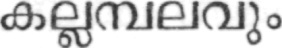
കല്ലമ്പലവും
